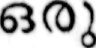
ഒരു
